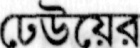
ঢেউয়ের
